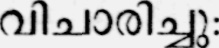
വിചാരിച്ചു:
